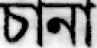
চানা
